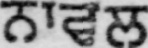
ਨਾਵਲ
